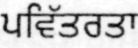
ਪਵਿੱਤਰਤਾ
